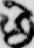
છે
